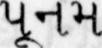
પૂનમ
